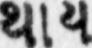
થાય
